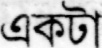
একটা
